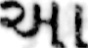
આ
